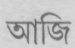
আজি
